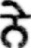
ਨੇ
